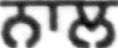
ਨਾਲ
